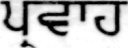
ਪ੍ਰਵਾਹ
